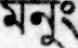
মনুং
